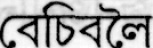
বেচিবলৈ
